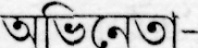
অভিনেতা-
